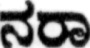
ನರಾ
